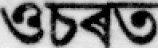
ওচৰত
